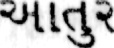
આતુર
